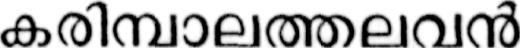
കരിമ്പാലത്തലവന്‍
